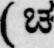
(ಚ
